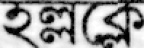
হল্লক্লে
